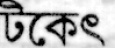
টিকেৎ
